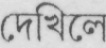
দেখিলে
